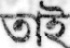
তাই
